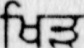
ਖਿੜ
